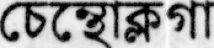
চেন্থোক্লগা
